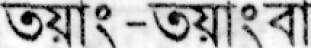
তয়াং-তয়াংবা
